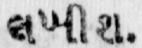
લખીશ.
